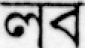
লব
